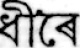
ধীৰে
